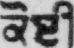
ਕੋਈ
